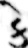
કે
